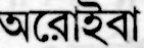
অরোইবা
